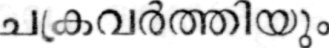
ചക്രവര്‍ത്തിയും
